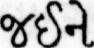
જઈને
